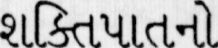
શક્તિપાતનો
